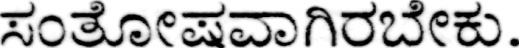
ಸಂತೋಷವಾಗಿರಬೇಕು.
